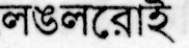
লেঙলরোই
